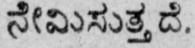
ನೇಮಿಸುತ್ತದೆ.
